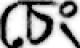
চেং
